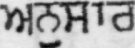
ਅਨੁਸਾਰ
